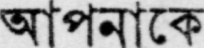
আপনাকে
